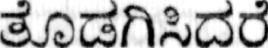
ತೊಡಗಿಸಿದರೆ
